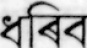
ধৰিব
